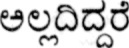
ಅಲ್ಲದಿದ್ದರೆ
